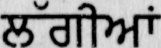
ਲੱਗੀਆਂ
